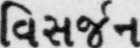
વિસર્જન
